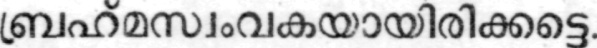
ബ്രഹ്മസ്വംവകയായിരിക്കട്ടെ.
